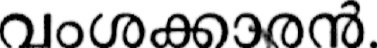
വംശക്കാരന്‍.
